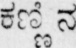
ಕಣ್ಣಿನ
